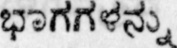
ಭಾಗಗಳನ್ನು
